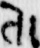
તો
